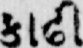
કાઢી
